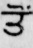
ਤੋਂ
